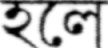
হলে
